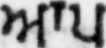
ਆਪ
